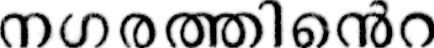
നഗരത്തിന്റെ
